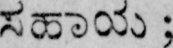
ಸಹಾಯ;
